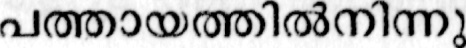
പത്തായത്തില്‍നിന്നു
